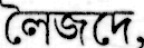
লৈজদে,
